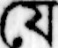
যে
